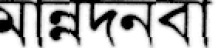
মান্নদনবা
